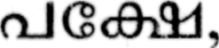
പക്ഷേ,
